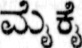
ಮೈಕೈ
